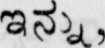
ಇನ್ನು,
